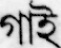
গাই
